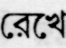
রেখে
